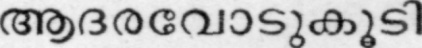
ആദരവോടുകൂടി
